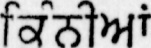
ਕਿੰਨੀਆਂ
